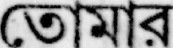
তোমার
